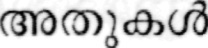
അതുകള്‍
